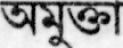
অমুক্তা
